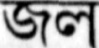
জল
